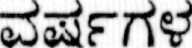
ವರ್ಷಗಳ
